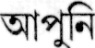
আপুনি
